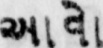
આવો
